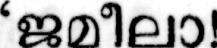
'ജമീലാ!
